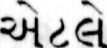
એટલે
